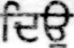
ਦਿਉ
